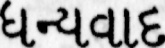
ધન્યવાદ
